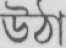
উঠা
